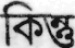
কিন্তু
